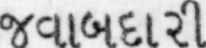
જવાબદારી
